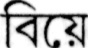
বিয়ে
